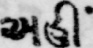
અહીં
